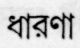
ধারণা
